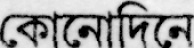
কোনোদিনে
